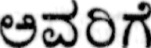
ಅವರಿಗೆ
